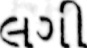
લગી
